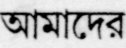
আমাদের
